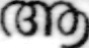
ആ
